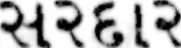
સરદાર
